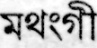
মথংগী
